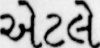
એટલે
